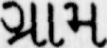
ગ્રામ
